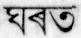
ঘৰত
